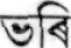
ভৰি
